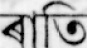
ৰাতি
